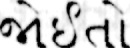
જોઈતો
